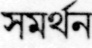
সমর্থন
